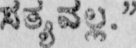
ಸತ್ಯವಲ್ಲ.”
